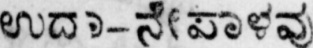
ಉದಾ-ನೇಪಾಳವು
